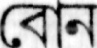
বোন
